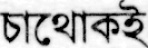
চাথোকই
